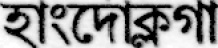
হাংদোক্লগা
